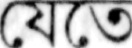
যেতে
